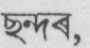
ছন্দৰ,
